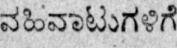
ವಹಿವಾಟುಗಳಿಗೆ
